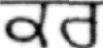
ਕਰ
